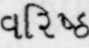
વરિષ્ઠ
